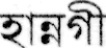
হান্নগী
